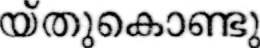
യ്തുകൊണ്ടു
